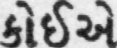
કોઈએ
